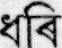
ধৰি
